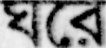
ঘরে
